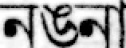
নঙনা
